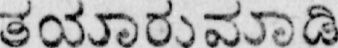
ತಯಾರುಮಾಡಿ
